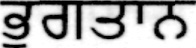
ਭੁਗਤਾਨ
